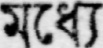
মধ্যে
